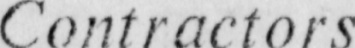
Contractors
